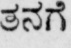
ತನಗೆ
